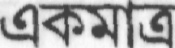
একমাত্র
